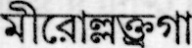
মীরোল্লক্ত্রগা
